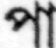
পা
